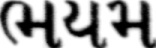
ભયમ
